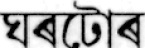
ঘৰটোৰ
